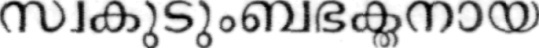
സ്വകുടുംബഭക്തനായ
